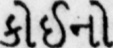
કોઈનો
